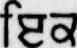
ਇਕ
